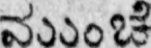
ಮುಂಚೆ
